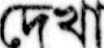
দেখা
